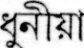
ধুনীয়া
